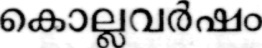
കൊല്ലവര്‍ഷം
